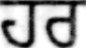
ਹਰ
